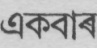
একবাৰ
